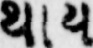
થાય
